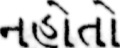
નહોતો
